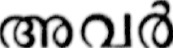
അവര്‍
